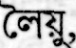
লৈয়ু,
